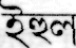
ইহুল
